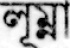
লূম্না
